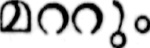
മററും
